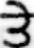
ਤੇ
